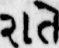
રાતે
